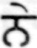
ਨੇ
